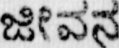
ಜೀವನ
